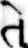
તે
